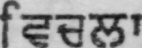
ਵਿਚਲਾ
